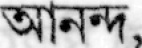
আনন্দ,
